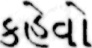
કહેવો
